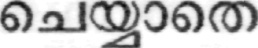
ചെയ്യാതെ
